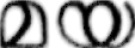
മയ
